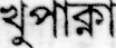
খুপাক্না
